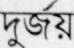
দুর্জয়
